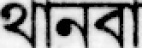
থানবা
